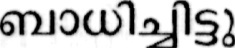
ബാധിച്ചിട്ടു
